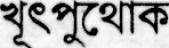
খূৎপুথোক
